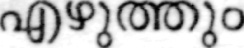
എഴുത്തും
